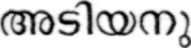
അടിയനു
